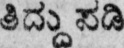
ತಿದ್ದುಪಡಿ
